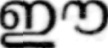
ഈ
